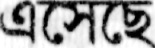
এসেছে
